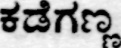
ಕಡೆಗಣ್ಣ
